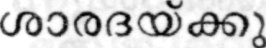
ശാരദയ്ക്കു
